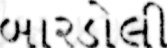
બારડોલી
